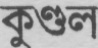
কুণ্ডল
